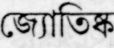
জ্যোতিষ্ক
